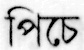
পিচে
